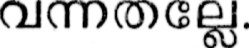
വന്നതല്ലേ.
